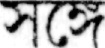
সঙ্গে
